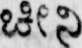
ಚೀನಿ
